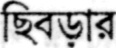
ছিবড়ার
